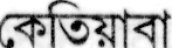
কেতিয়াবা
